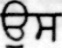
ਉਸ
